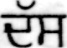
ਦੱਸ
